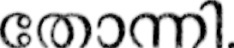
തോന്നി.
